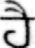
ਹੈ
